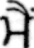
ਮੈਂ
